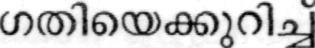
ഗതിയെക്കുറിച്ച്
